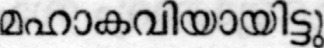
മഹാകവിയായിട്ടു
